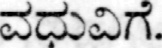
ವಧುವಿಗೆ.
